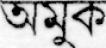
অমুক
